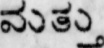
ಮತ್ತು
